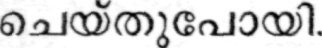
ചെയ്തുപോയി.
